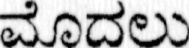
ಮೊದಲು
